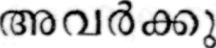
അവര്‍ക്കു
